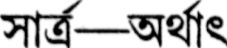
সার্ত্র-অর্থাৎ
